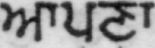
ਆਪਣਾ
